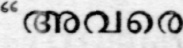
"അവരെ
